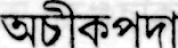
অচীকপদা
